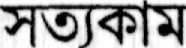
সত্যকাম
